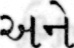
અને
